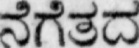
ನೆಗೆತದ
